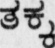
ತಕ್ಕ
